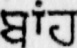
ਬਾਂਹ
